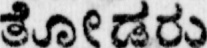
ತೋಡರು
